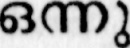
ഒന്നു
